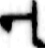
ન
